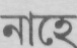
নাহে
